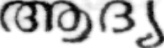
ആദ്യ
